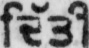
ਦਿੱਤੀ
